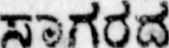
ಸಾಗರದ
